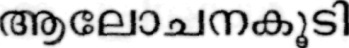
ആലോചനകൂടി
